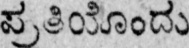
ಪ್ರತಿಯೊಂದು
